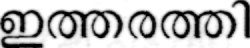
ഇത്തരത്തി
